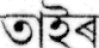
তাইৰ
